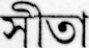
সীতা
